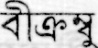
বীক্রম্বু
